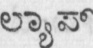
ಲ್ಯಾಪ್
